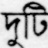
দুটি
